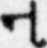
ન
